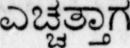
ಎಚ್ಚತ್ತಾಗ
